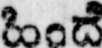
ಹಿಂದೆ
